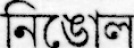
নিঙোল
